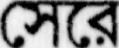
সেরে
